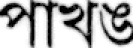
পাখঙ
